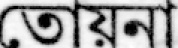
তোয়না
